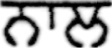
ਨਾਲ
